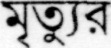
মৃত্যুর
